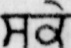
ਸਕੇ
